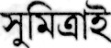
সুমিত্রাই
